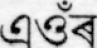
এওঁৰ
